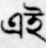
এই
